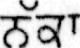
ਨੱਕਾ
